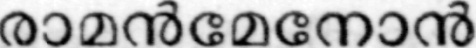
രാമന്‍മേനോന്‍
